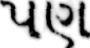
પણ
